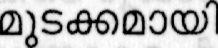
മുടക്കമായി
